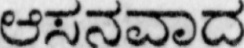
ಆಸನವಾದ
